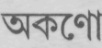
অকণো
